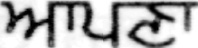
ਆਪਣਾ
